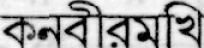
কনবীরমখি
